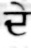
ਦੇ
